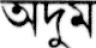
অদুম
